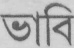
ভাবি
